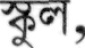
স্কুল,
